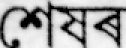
শেষৰ
